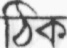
ঠিক
